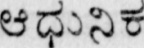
ಆಧುಕ
